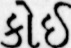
કોઈ
